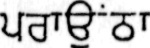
ਪਰਾਉਂਠਾ
